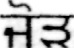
ਜੋੜ
